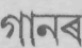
গানৰ
